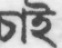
চাই
